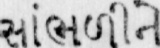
સાંભળીને
